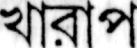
খারাপ
